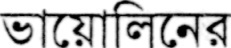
ভায়োলিনের
